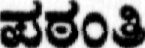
ಪಠಂತಿ
